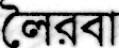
লৈরবা
